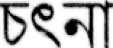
চৎনা
